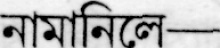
নামানিলে-
